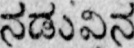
ನಡುವಿನ
